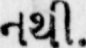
નથી.
